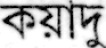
কয়াদু
